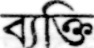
ব্যক্তি
